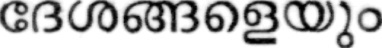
ദേശങ്ങളെയും
